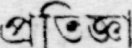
প্রতিজ্ঞা
